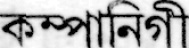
কম্পানিগী
